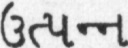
ઉત્પન્ન
